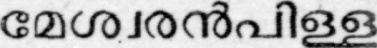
മേശ്വരന്‍പിള്ള
